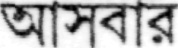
আসবার
